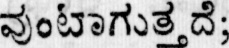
ವುಂಟಾಗುತ್ತದೆ;
